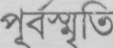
পূৰ্বস্মৃতি
